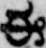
ಈ
